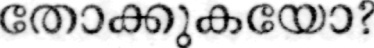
തോക്കുകയോ?
